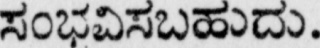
ಸಂಭವಿಸಬಹುದು.
